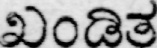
ಖಂಡಿತ
